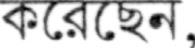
করেছেন,
